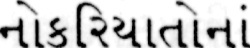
નોકરિયાતોનાં
